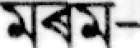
মৰম-
